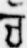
ਚੋ
